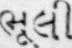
ભૂલી
